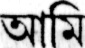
আমি
